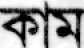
কাম
